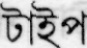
টাইপ
